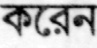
করেন
